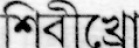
শিবীখ্রো
